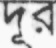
দূর
